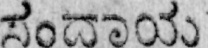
ಸಂದಾಯ
